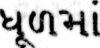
ધૂળમાં
